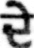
ਦੇ
